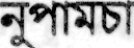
নুপামচা
